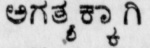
ಅಗತ್ಯಕ್ಕಾಗಿ
